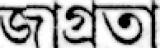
জাগ্রতা
